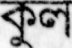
কুল
